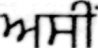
ਅਸੀਂ
